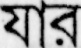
যার
